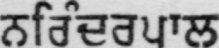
ਨਰਿੰਦਰਪਾਲ
